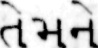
તેમને
